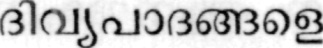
ദിവ്യപാദങ്ങളെ
